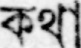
কথা
